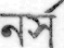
নর্স
